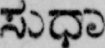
ಸುಧಾ
